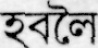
হবলৈ
